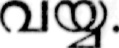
വയ്യ.
